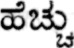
ಹೆಚ್ಚು
